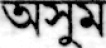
অসুম
